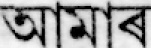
আমাৰ
